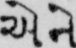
એને
